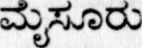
ಮೈಸೂರು
